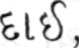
દાઈ,
